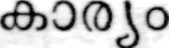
കാര്യം
